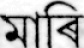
মাৰি
